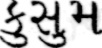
કુસુમ
